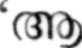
'ആ
